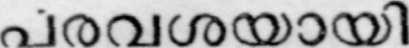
പരവശയായി
